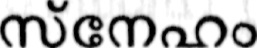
സ്നേഹം
